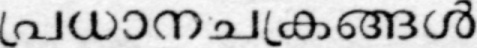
പ്രധാനചക്രങ്ങള്‍
